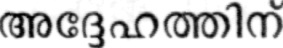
അദ്ദേഹത്തിന്
